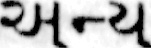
અન્ય
